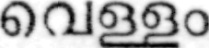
വെള്ളം
